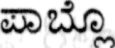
ಪಾಬ್ಲೊ
